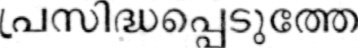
പ്രസിദ്ധപ്പെടുത്തേ
